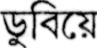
ডুবিয়ে
